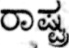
ರಾಷ್ಟ್ರ
